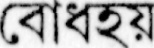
বোধহয়
